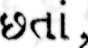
છતાં,
